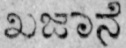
ಖಜಾನೆ
